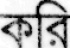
করি
